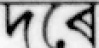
দৰে
